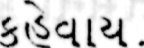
કહેવાય.
